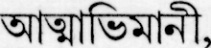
আত্মাভিমানী,
